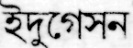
ইদুগেসন
